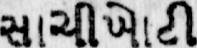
સાચીખોટી
